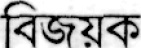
বিজয়ক
